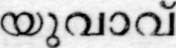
യുവാവ്
